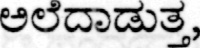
ಅಲೆದಾಡುತ್ತ,
